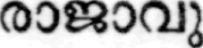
രാജാവു
